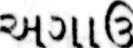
અગાઉ
